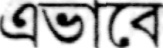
এভাবে
